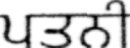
ਪਤਨੀ
